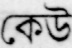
কেউ
